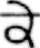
ਕੇ
